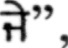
ਜੇ'',
